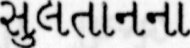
સુલતાનના
